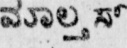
ಮಾಲ್ತಸ್
